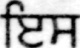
ਇਸ
